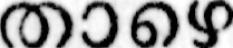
താഴെ
